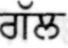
ਗੱਲ
